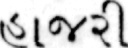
હાજરી
